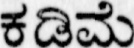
ಕಡಿಮೆ
